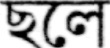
ছলে
